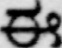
ಈ
